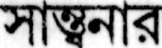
সান্ত্বনার
